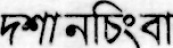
দশানচিংবা
